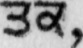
ਤਕ,
